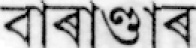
বাৰাণ্ডাৰ
